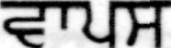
ਵਾਪਸ
